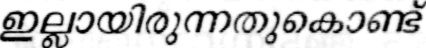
ഇല്ലായിരുന്നതുകൊണ്ട്
